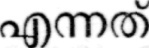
എന്നത്
